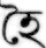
হৈ
